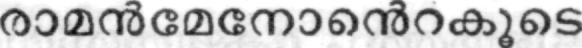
രാമന്‍മേനോന്റെകൂടെ
